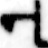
ન
